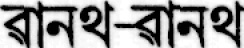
ৱানথ-ৱানথ
